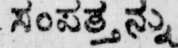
ಸಂಪತ್ತನ್ನು
